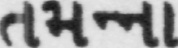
તમન્ના
